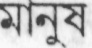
মানুষ
